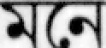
মনে
